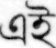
এই
